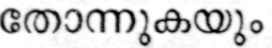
തോന്നുകയും
